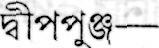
দ্বীপপুঞ্জ-
